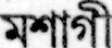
মশাগী
